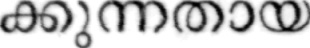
ക്കുന്നതായ
